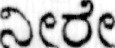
ನೀರೇ
